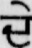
ਦੇ
